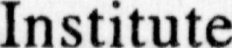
Institute
